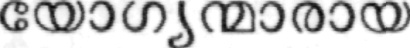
യോഗ്യന്മാരായ
